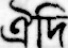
ঐদি
